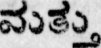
ಮತ್ತು
